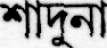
শাদুনা
